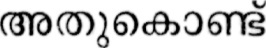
അതുകൊണ്ട്
